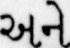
અને
